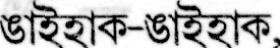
ঙাইহাক-ঙাইহাক,
